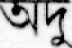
অদু
